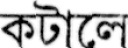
কটালে
